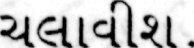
ચલાવીશ.
